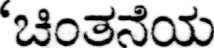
'ಚಿಂತನೆಯ
